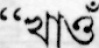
"খাওঁ
